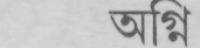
অগ্নি
